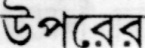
উপরের
